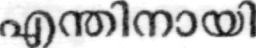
എന്തിനായി
